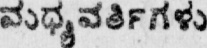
ಮಧ್ಯವರ್ತಿಗಳು
